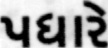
પધારે
